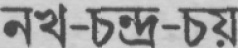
নখ-চন্দ্ৰ-চয়
